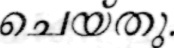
ചെയ്തു.
